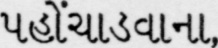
પહોંચાડવાના,
